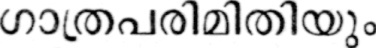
ഗാത്രപരിമിതിയും
